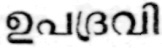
ഉപദ്രവി
